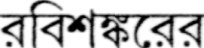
রবিশঙ্করের
